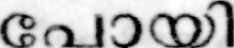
പോയി
